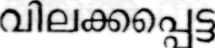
വിലക്കപ്പെട്ട
